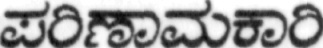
ಪರಿಣಾಮಕಾರಿ
